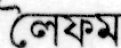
লৈফম
